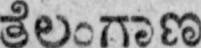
ತೆಲಂಗಾಣ
